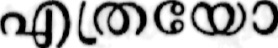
എത്രയോ
